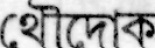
থৌদোক
